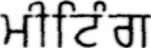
ਮੀਟਿੰਗ
